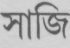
সাজি
